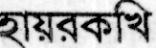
হায়রকখি
